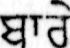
ਬਾਰੇ
